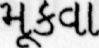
મૂકવા
